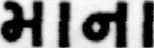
માના
